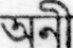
অনী
